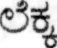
ಲೆಕ್ಕ
